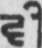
ਵੀ
